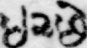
ઇચ્છે
